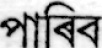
পাৰিব
